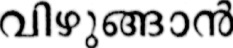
വിഴുങ്ങാന്‍
